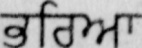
ਭਰਿਆ
